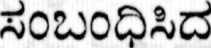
ಸಂಬಂಧಿಸಿದ
